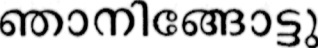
ഞാനിങ്ങോട്ടു
